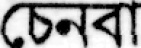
চেনবা
